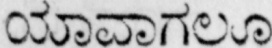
ಯಾವಾಗಲೂ
